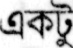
একটু
